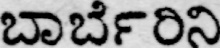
ಬಾರ್ಬೆರಿನಿ
